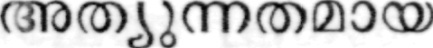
അത്യുന്നതമായ
